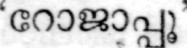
‘റോജാപ്പൂ’
